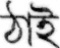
ঠাই
